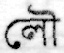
লৌ
